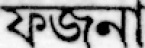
ফজনা
